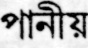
পানীয়
